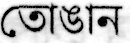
তোঙান
